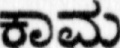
ಕಾಮ
